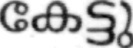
കേട്ടു
